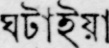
ঘটাইয়া
